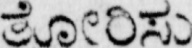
ತೋರಿಸು
